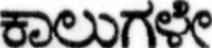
ಕಾಲುಗಳೇ
